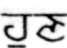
ਹੁਣ
